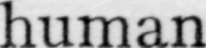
human
